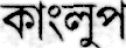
কাংলুপ
